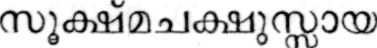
സൂക്ഷ്മചക്ഷുസ്സായ
